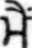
ਮੈਂ
